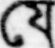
যে
